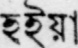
হইয়া
